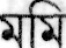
মমি
